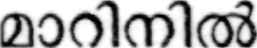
മാറിനില്‍
